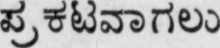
ಪ್ರಕಟವಾಗಲು
